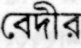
বেদীর
